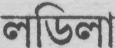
লড়িলা
